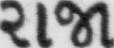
રાજા
